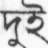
দুই
